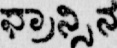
ಫ್ರಾನ್ಸಿನ
